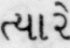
ત્યારે
